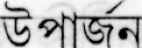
উপার্জন
